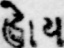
હોય
